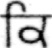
ਕਿ
